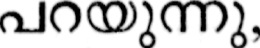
പറയുന്നു,
